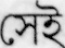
সেই
